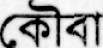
কৌবা
